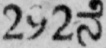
292ನೆ
